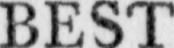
BEST
